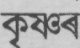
কৃষ্ণৰ
